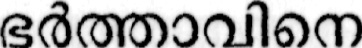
ഭര്‍ത്താവിനെ
